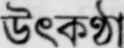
উৎকণ্ঠা
